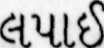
લપાઈ
